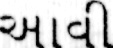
આવી
